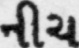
નીચ
